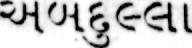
અબદુલ્લા
